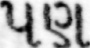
પણ
